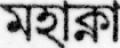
মহাক্না
